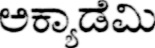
ಅಕ್ಯಾಡೆಮಿ
